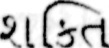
શક્તિ
